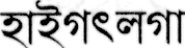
হাইগৎলগা
